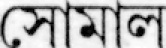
সোমাল
